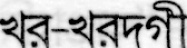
খর-খরদগী
